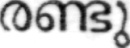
രണ്ടു
